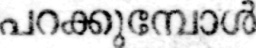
പറക്കുമ്പോള്‍
